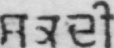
ਸਕਦੀ
